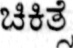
ಚಿಕಿತ್ಸೆ
